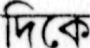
দিকে
